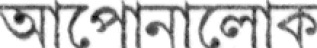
আপোনালোক
